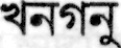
খনগনু
